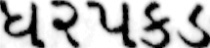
ધરપકડ
